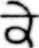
ਕੇ
